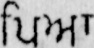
ਪਿਆ
